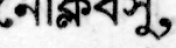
নোক্লবসু,
